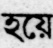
হয়ে
